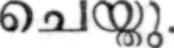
ചെയ്തു.
